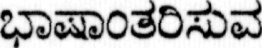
ಭಾಷಾಂತರಿಸುವ
